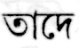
তাদে
